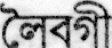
লৈবগী
